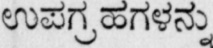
ಉಪಗ್ರಹಗಳನ್ನು
